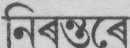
নিৰন্তৰে
